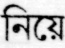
নিয়ে
